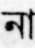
না
